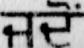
ਜਦੋਂ
